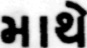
માથે
